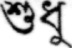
শুধু
